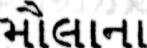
મૌલાના
